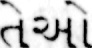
તેઓ
